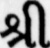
શ્રી
